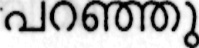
പറഞ്ഞു
